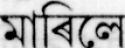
মাৰিলে
